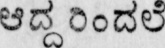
ಆದ್ದರಿಂದಲೆ
